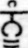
ਨੂੰ
